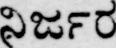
ನಿರ್ಜರ
